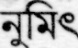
নুমিৎ
